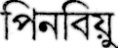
পিনবিয়ু
